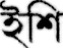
ইশি
